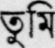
তুমি
